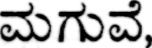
ಮಗುವೆ,
